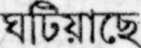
ঘটিয়াছে
